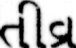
તીવ્ર
